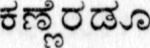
ಕಣ್ಣೆರಡೂ
